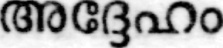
അദ്ദേഹം
